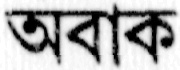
অবাক
